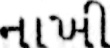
નાખી
